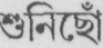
শুনিছোঁ
